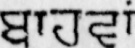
ਬਾਹਵਾਂ
